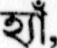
হ্যাঁ,
